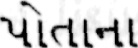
પોતાના
